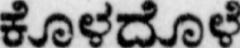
ಕೊಳದೊಳೆ
